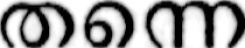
തന്നെ
